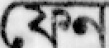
ফেন
